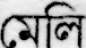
মেলি
